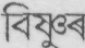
বিষ্ণুৰ
